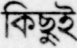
কিছুই
